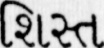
શિસ્ત
